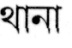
থানা
